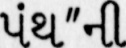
પંથ"ની
